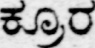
ಕ್ರೂರ
